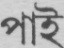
পাই
